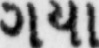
ગયા
